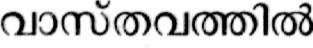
വാസ്തവത്തില്‍
